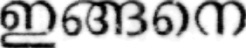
ഇങ്ങനെ
